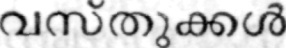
വസ്തുക്കള്‍
